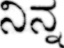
ನಿನ್ನ
